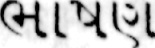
ભાષણ
